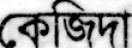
কেজিদা
